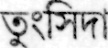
তুংসিদা
